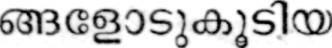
ങ്ങളോടുകൂടിയ
